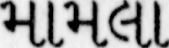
મામલા
